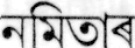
নমিতাৰ
